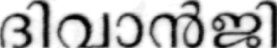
ദിവാന്‍ജി
